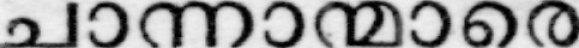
ചാന്നാന്മാരെ
